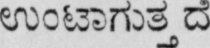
ಉಂಟಾಗುತ್ತದೆ
